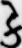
કે
